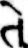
તે
